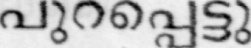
പുറപ്പെട്ടു
